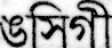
ঙসিগী
